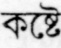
কষ্টে
